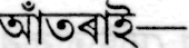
আঁতৰাই-
